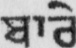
ਬਾਰੇ
